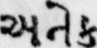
અનેક
